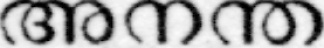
അനന്ത
